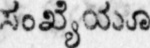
ಸಂಖ್ಯೆಯೂ
